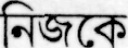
নিজকে
